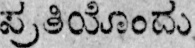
ಪ್ರತಿಯೊಂದು
